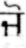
ਜੋ
